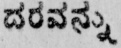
ದರವನ್ನು
